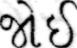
જોઈ
